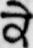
ਕੇ
